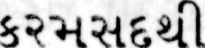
કરમસદથી
